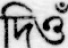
দিওঁ
